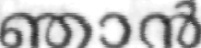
ഞാന്‍
